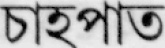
চাহপাত
